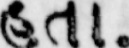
હતા.
